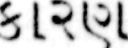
કારણ
